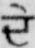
ਦੇ
